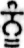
ਨੂੰ
